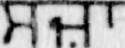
ਸਜ਼ਾ
